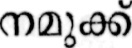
നമുക്ക്
